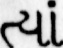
ત્યાં
